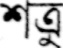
শত্রু
